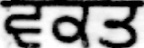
ਵਕਤ
